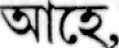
আহে,
